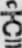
ਨੂੰ
